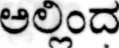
ಅಲ್ಲಿಂದ
